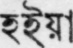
হইয়া
